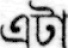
এটা
